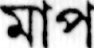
মাপ
